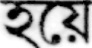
হয়ে
